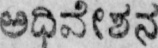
ಅಧಿವೇಶನ
